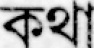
কথা
